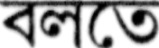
বলতে
